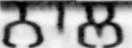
ਨਾਲ
